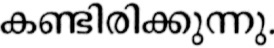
കണ്ടിരിക്കുന്നു.
